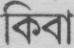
কিবা
